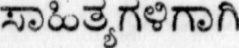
ಸಾಹಿತ್ಯಗಳಿಗಾಗಿ
